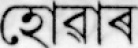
হোৱাৰ
